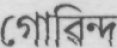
গোৱিন্দ
